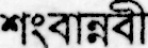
শংবান্নবী
